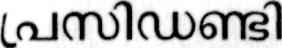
പ്രസിഡണ്ടി
